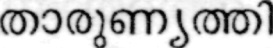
താരുണ്യത്തി
